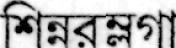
শিন্নরম্লগা
